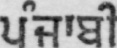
ਪੰਜਾਬੀ
